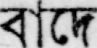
বাদে
